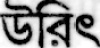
উরিৎ
